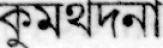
কুমথদনা
